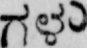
ಗಳು
